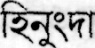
হিনুংদা
